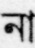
না
